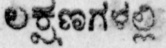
ಲಕ್ಷಣಗಳಲ್ಲಿ
